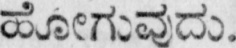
ಹೋಗುವುದು.
